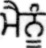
ਮੈਨੂੰ
